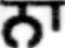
ਨਾ
